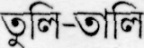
তুলি-তালি
